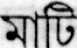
মাটি
